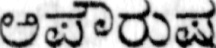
ಅಪೌರುಷ
